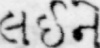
લઈને
